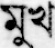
মুখ
